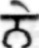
ਨੇ
